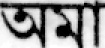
অমা
